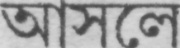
আসলে
